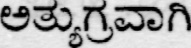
ಅತ್ಯುಗ್ರವಾಗಿ
